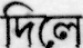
দিলে
